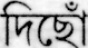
দিছোঁ
